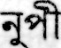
নুপী
